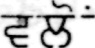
ਵਲੋਂ
